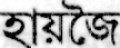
হায়জৈ
